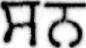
ਸਨ
